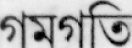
গমগতি
